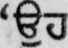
'ਉਹ
